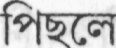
পিছলে
